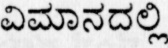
ವಿಮಾನದಲ್ಲಿ
